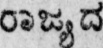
ರಾಜ್ಯದ
